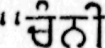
''ਚੰਨੀ
